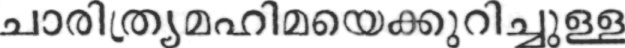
ചാരിത്ര്യമഹിമയെക്കുറിച്ചുള്ള
